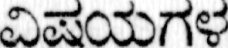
ವಿಷಯಗಳ
